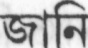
জানি
